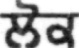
ਲੋਕ
